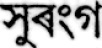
সুৰংগ
